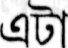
এটা
